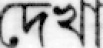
দেখা
